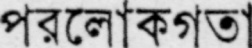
পরলোকগতা
